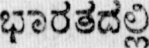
ಭಾರತದಲ್ಲಿ
